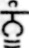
ਨੂੰ
